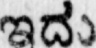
ಇದು
